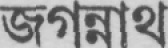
জগন্নাথ
